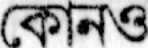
কোনও
